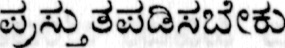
ಪ್ರಸ್ತುತಪಡಿಸಬೇಕು
